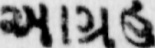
આગ્રહ
